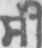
ਸੀ
